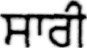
ਸਾਰੀ
